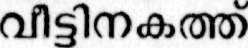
വീട്ടിനകത്ത്
